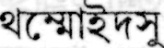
থম্মোইদসু
